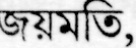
জয়মতি,
